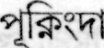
পূক্নিংদা
